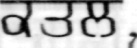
ਕਤਲ,
